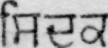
ਸਿਦਕ
